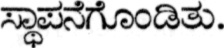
ಸ್ಥಾಪನೆಗೊಂಡಿತು.
